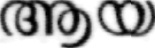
ആയ
